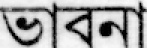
ভাবনা
